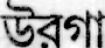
উরগা
